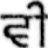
ਵੀ
